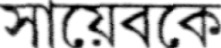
সায়েবকে
